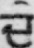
ਦੇ
